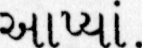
આપ્યાં.
